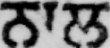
ਨਾਲ
